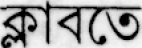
ক্লাবতে
